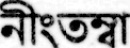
নীংতম্বা
